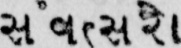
સંવત્સરો
